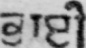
ਭਾਈ
